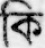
কি
